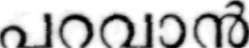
പറവാന്‍
